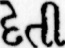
દેતી
